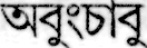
অবুংচাবু
